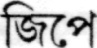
জিপে
